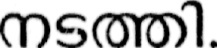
നടത്തി.
